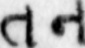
તને
